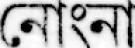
নোংনা
